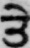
ਤੇ
